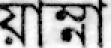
য়াম্না
